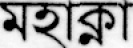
মহাক্না
